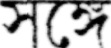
সঙ্গে
